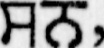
ਸਨ,
